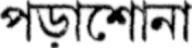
পড়াশোনা
